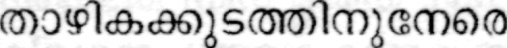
താഴികക്കുടത്തിനുനേരെ
